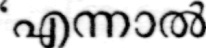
‘എന്നാല്‍
